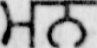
ਮਨ
